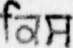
ਕਿਸ
